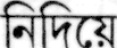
নিদিয়ে
